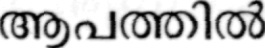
ആപത്തില്‍
